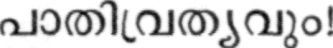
പാതിവ്രത്യവും!
